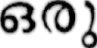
ഒരു
